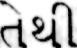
તેથી
